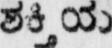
ಶಕ್ತಿಯ
